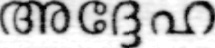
അദ്ദേഹ
